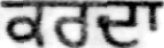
ਕਰਦਾ
